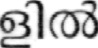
ളില്‍
